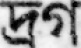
দ্রগ
